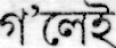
গ'লেই
